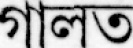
গালত
